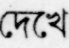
দেখে
